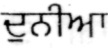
ਦੁਨੀਆ
